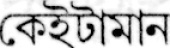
কেইটামান
